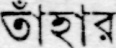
তাঁহার
